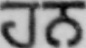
ਹਨ
